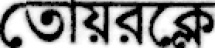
তোয়রক্লে
